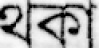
থকা
